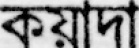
কয়াদা
